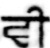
ਵੀ
